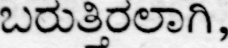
ಬರುತ್ತಿರಲಾಗಿ,
